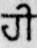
ਹੀ
